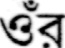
ওঁর
